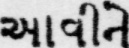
આવીને
